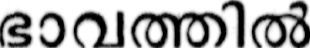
ഭാവത്തില്‍
